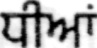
ਧੀਆਂ
